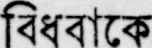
বিধবাকে
